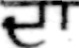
ਦਾ
